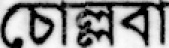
চোল্লবা
